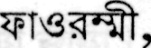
ফাওরম্মী,
